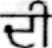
ਦੀ
